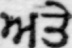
ਅਤੇ
